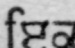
ਇਕ
